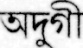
অদুগী
